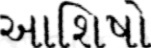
આશિષો
